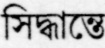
সিদ্ধান্তে
